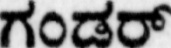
ಗಂಡರ್
